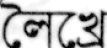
লৈখ্রে
